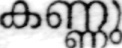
കണ്ണു
